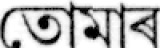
তোমাৰ
